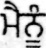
ਮੈਨੂੰ
